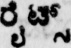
ರೈಟ್ಸ್
